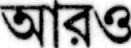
আরও
